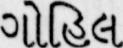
ગોહિલ
